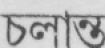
চলান্ত
